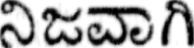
ನಿಜವಾಗಿ
